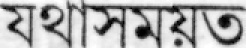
যথাসময়ত
